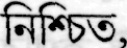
নিশ্চিত,
